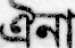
ঐনা
